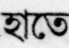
হাতে
